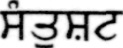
ਸੰਤੁਸ਼ਟ
